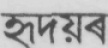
হৃদয়ৰ
